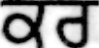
ਕਰ
